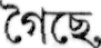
গৈছে,
